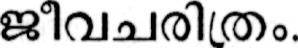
ജീവചരിത്രം.
